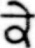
ਕੇ
